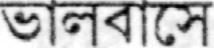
ভালবাসে
